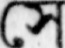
সে
